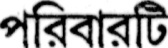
পরিবারটি
